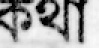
কথা
